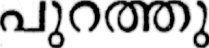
പുറത്തു
